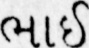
ભાઈ
